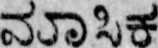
ಮಾಸಿಕ
